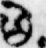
છે.
